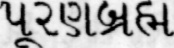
પૂરણબ્રહ્મ
